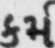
કર્મ
